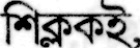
শিক্লকই,
